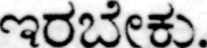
ಇರಬೇಕು.
